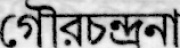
গৌরচন্দ্রনা
